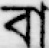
বা
